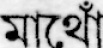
মাথোঁ
